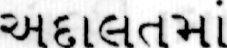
અદાલતમાં
